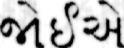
જોઈએ
